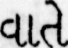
વાતે
